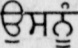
ਉਸਨੂੰ
